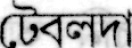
টেবলদা
